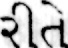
રીતે
